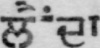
ਲੈਂਦਾ
